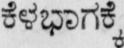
ಕೆಳಭಾಗಕ್ಕೆ
